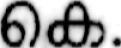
കെ.
